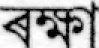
ৰক্ষা
